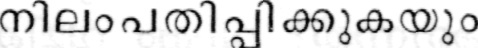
നിലംപതിപ്പിക്കുകയും
